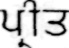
ਪ੍ਰੀਤ
